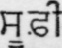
ਸੂਫ਼ੀ
